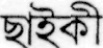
ছাইকী
